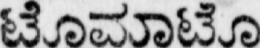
ಟೊಮಾಟೊ
